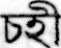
চহী
